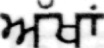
ਅੱਖਾਂ
